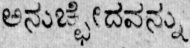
ಅನುಚ್ಛೇದವನ್ನು
